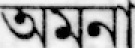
অমনা
